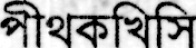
পীথকখিসি
